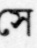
সে
